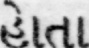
હોતા
